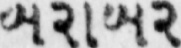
બરાબર
